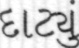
દાટ્યું
